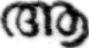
ആ
